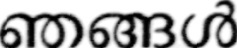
ഞങ്ങള്‍
